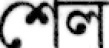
শেল
